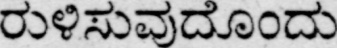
ರುಳಿಸುವುದೊಂದು
